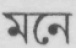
মনে
